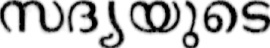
സദ്യയുടെ
